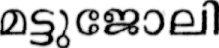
മട്ടുജോലി
